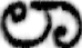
ಲಾ
